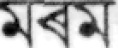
মৰম
